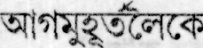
আগমুহূর্তলৈকে
